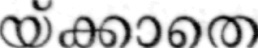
യ്ക്കാതെ
